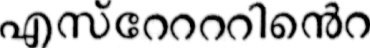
എസ്റേറററിന്റെ
